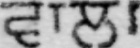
ਵਾਲਾ
